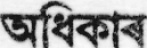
অধিকাৰ
